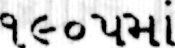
૧૯૦૫માં
